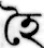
হৈ
